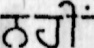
ਨਹੀਂ
